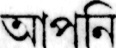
আপনি
